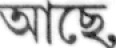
আছে,
